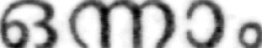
ഒന്നാം
